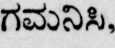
ಗಮನಿಸಿ,
